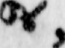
જ,
